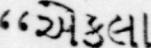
"એકલા
